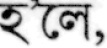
হ'লে,
